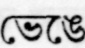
ভেঙে
